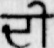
ਦੀ
